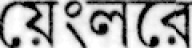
য়েংলরে
